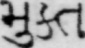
મુક્ત
